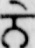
ਨੇ
